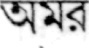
অমর
